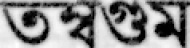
তম্বগুম
